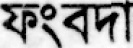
ফংবদা
